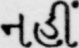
નહીં
